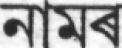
নামৰ
